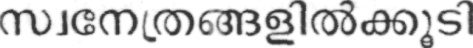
സ്വനേത്രങ്ങളില്‍ക്കൂടി
